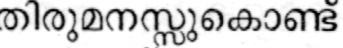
തിരുമനസ്സുകൊണ്ട്
